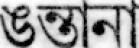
ঙন্তানা
